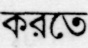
করতে
